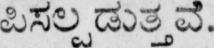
ಪಿಸಲ್ಪಡುತ್ತವೆ.
